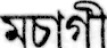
মচাগী
